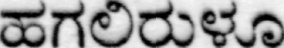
ಹಗಲಿರುಳೂ
